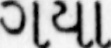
ગયા
